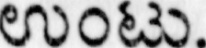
ಉಂಟು.
